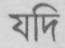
যদি
